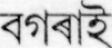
বগৰাই
